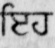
ਇਹ
